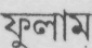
ফুলাম
